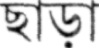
ছাড়া
